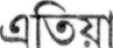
এতিয়া
